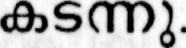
കടന്നു.
